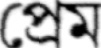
প্রেম
